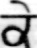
ਕੇ
